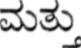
ಮತ್ತು
